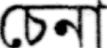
চেনা
